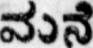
ಮನೆ
